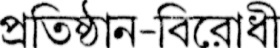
প্রতিষ্ঠান-বিরোধী
